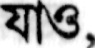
যাও,
